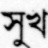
সুখ
